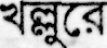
খল্লুরে
